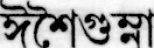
ঈশৈগুম্না
